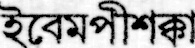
ইবেমপীশক্কা
